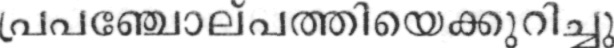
പ്രപഞ്ചോല്പത്തിയെക്കുറിച്ചു
